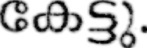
കേട്ടു.
